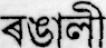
ৰঙালী
